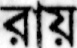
রায়
